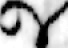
જ
